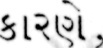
કારણે,
